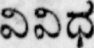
ವಿವಿಧ
